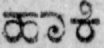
ಹಾಕಿ
